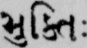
મુક્તિ:
